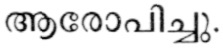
ആരോപിച്ചു.
